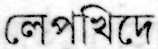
লেপখিদে
